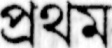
প্রথম
